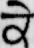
ਕੇ
